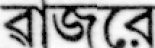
ৱাজরে
